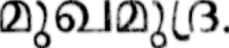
മുഖമുദ്ര.
